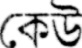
কেউ
